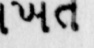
વખતે
